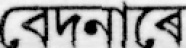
বেদনাৰে
